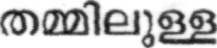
തമ്മിലുള്ള
